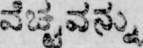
ವಚ್ಚವನ್ನು
